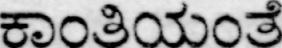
ಕಾಂತಿಯಂತೆ
